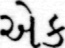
એક
